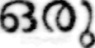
ഒരു
